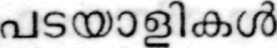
പടയാളികള്‍
